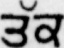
ਤੱਕ
